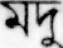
মদু
